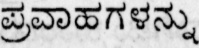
ಪ್ರವಾಹಗಳನ್ನು
